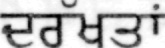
ਦਰੱਖਤਾਂ
